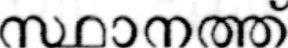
സ്ഥാനത്ത്
